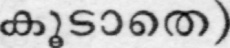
കൂടാതെ)
